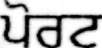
ਪੋਰਟ
